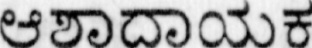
ಆಶಾದಾಯಕ
